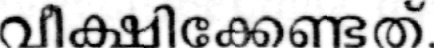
വീക്ഷിക്കേണ്ടത്.
